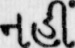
નહીં
